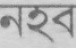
নহব
